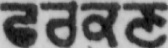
ਫਰਕਣ
